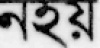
নহয়
